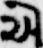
એ
